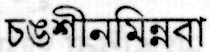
চঙশীনমিন্নবা
